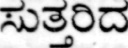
ಸುತ್ತರಿದ
